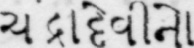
ચંદ્રાદેવીનો
